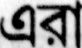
এরা
